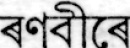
ৰণবীৰে
